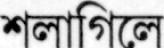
শলাগিলে
